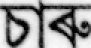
চাৰু
